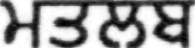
ਮਤਲਬ
